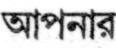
আপনার
